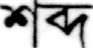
শব্দ
